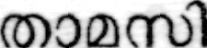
താമസി
